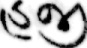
હજી
